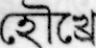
হৌখ্রে
